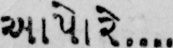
આપોરે....
